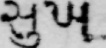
સુખ
